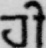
ਹੀ
